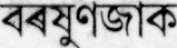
বৰষুণজাক
